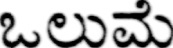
ಒಲುಮೆ
